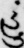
હું
